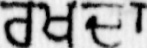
ਰਖਦਾ
